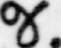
જ.
